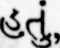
હતું,
